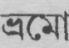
ভ্ৰমো
